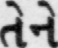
તેને
